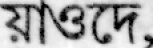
য়াওদে,
